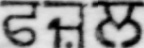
ਫਜ਼ਲ
